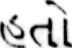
હતો
